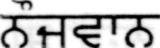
ਨੌਜਵਾਨ
